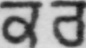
ਕਰ
